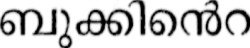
ബുക്കിന്റെ
